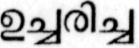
ഉച്ചരിച്ച
